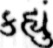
કહ્યું
